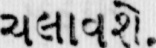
ચલાવશે.
